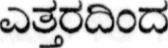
ಎತ್ತರದಿಂದ
